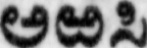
ಅಱಸಿ
